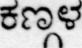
ಕಣ್ಗಳ
